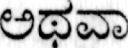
ಅಥವಾ
